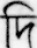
দি
